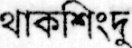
থাকশিংদু
